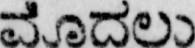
ಮೊದಲು
